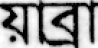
য়াব্রা
